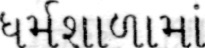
ધર્મશાળામાં
